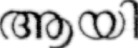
ആയി
